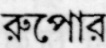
রুপোর
